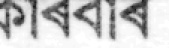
কাৰবাৰ
